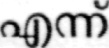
എന്ന്
